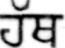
ਹੱਥ
